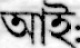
আই:
